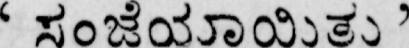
‘ಸಂಜೆಯಾಯಿತು’
